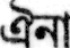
ঐনা
